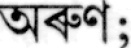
অৰুণ;
